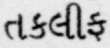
તકલીફ
